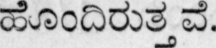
ಹೊಂದಿರುತ್ತವೆ.
